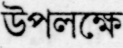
উপলক্ষে
